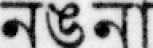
নঙনা
